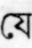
যে
